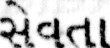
સેવાતા
